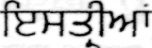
ਇਸਤ੍ਰੀਆਂ
